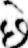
છે
